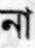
না
